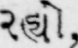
રહ્યો,
